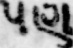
પણ
